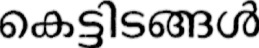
കെട്ടിടങ്ങള്‍
